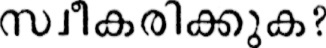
സ്വീകരിക്കുക?
